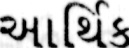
આર્થિક
